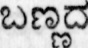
ಬಣ್ಣದ
